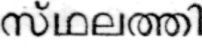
സ്ഥലത്തി
